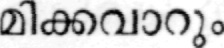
മിക്കവാറും
